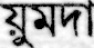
য়ুমদা
